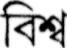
বিশ্ব
